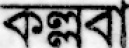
কল্লবা
